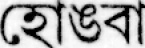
হোঙবা
